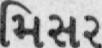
મિસર
